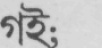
গই;
